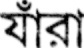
যাঁরা
